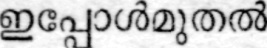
ഇപ്പോള്‍മുതല്‍
